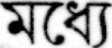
মধ্যে
